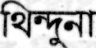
থিন্দুনা
